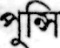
পুন্সি
